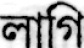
লাগি
